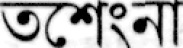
তশেংনা
